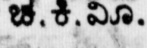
ಚ.ಕಿ.ಮೀ.
